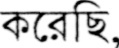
করেছি,
